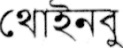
থোইনবু
